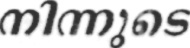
നിന്നുടെ
